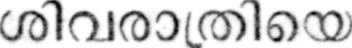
ശിവരാത്രിയെ
